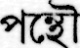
পন্থৌ
